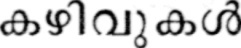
കഴിവുകള്‍
